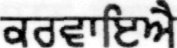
ਕਰਵਾਇਐ
